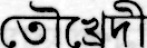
তৌখ্রেদী
